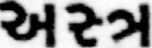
અસ્ત્ર
